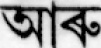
আৰু
